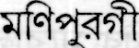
মণিপুরগী
